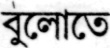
বুলোতে
